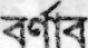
বর্ণাব
